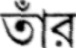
তাঁর
